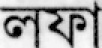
লফা
